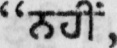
''ਨਹੀਂ,
